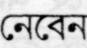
নেবেন
